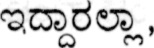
ಇದ್ದಾರಲ್ಲಾ,
